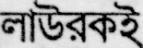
লাউরকই
